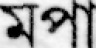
মপা
